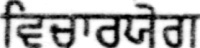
ਵਿਚਾਰਯੋਗ
